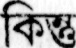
কিন্তু
